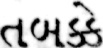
તબક્કે
